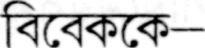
বিবেককে-
